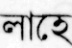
লাহে
